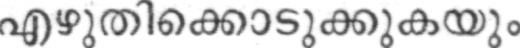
എഴുതിക്കൊടുക്കുകയും
